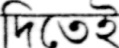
দিতেই
